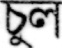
চুল
